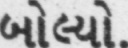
બોલ્યો.
